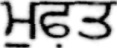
ਮੁਫ਼ਤ
